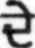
ਦੇ
